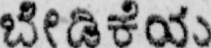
ಬೇಡಿಕೆಯ
